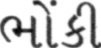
ભોંકી
